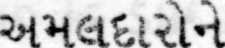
અમલદારોને
